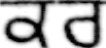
ਕਰ
